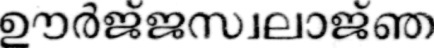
ഊര്‍ജ്ജസ്വലാജ്ഞ
